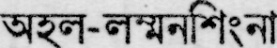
অহল-লম্মনশিংনা
